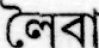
লৈবা
